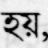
হয়,
